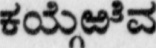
ಕಯ್ಗೆಱೆವ
